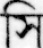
সি
